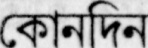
কোনদিন
